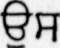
ਉਸ
